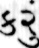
કરું
